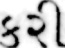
કરી
